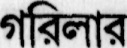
গরিলার
